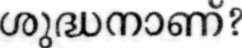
ശുദ്ധനാണ്?
